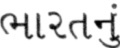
ભારતનું
